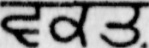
ਵਕਤ
